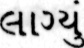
લાગ્યું
